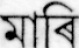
মাৰি
